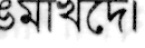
ঙমখিদে।
